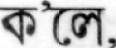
ক'লে,
